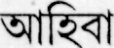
আহিবা
